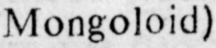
Mongoloid)
